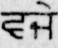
ਵਜੇ
